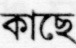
কাছে
